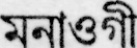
মনাওগী
